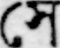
সে
